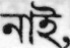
নাই,
